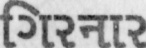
ગિરનાર
